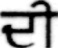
ਦੀ
